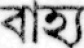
বাহ্য
